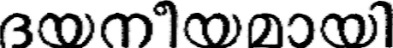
ദയനീയമായി
